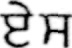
ਏਸ
